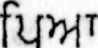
ਪਿਆ
